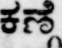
ಕಣ್ಗೆ
